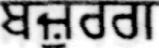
ਬਜ਼ੁਰਗ
